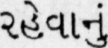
રહેવાનું
